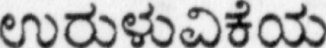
ಉರುಳುವಿಕೆಯ
